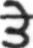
ਤੇ
